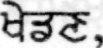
ਖੇਡਣ,
